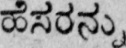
ಹೆಸರನ್ನು
